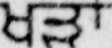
ਖੜਾ
